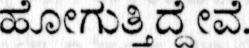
ಹೋಗುತ್ತಿದ್ದೇವೆ.
